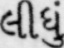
લીધું
